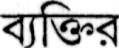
ব্যক্তির
